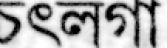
চৎলগা
